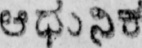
ಆಧುನಿಕ
